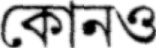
কোনও
